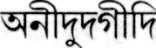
অনীদুদগীদি
